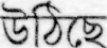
উঠিছে
